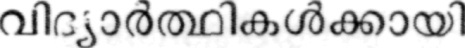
വിദ്യാര്‍ത്ഥികള്‍ക്കായി
